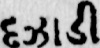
દઝાડી
